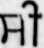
ਸੀ
